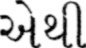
એથી
